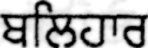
ਬਲਿਹਾਰ
